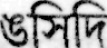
ঙসিদি
